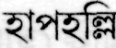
হাপহল্লি
